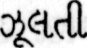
ઝૂલતી
